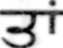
ਤਾਂ
